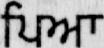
ਪਿਆ
